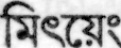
মিৎয়েং
